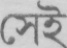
সেই
